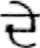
ਦੇ
